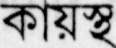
কায়স্থ
